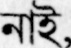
নাই,
